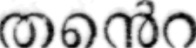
തന്റെ
